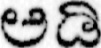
ಅಡಿ
